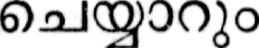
ചെയ്യാറും
